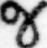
જ
